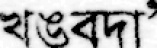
খঙবদা’
